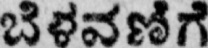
ಬೆಳವಣಿಗೆ
